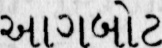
આગબોટ
